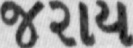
જરાય
